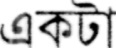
একটা
